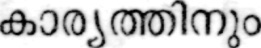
കാര്യത്തിനും
